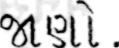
જાણો.
